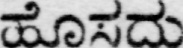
ಹೊಸದು
